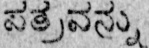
ಪತ್ರವನ್ನು
